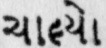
ચાલ્યો
